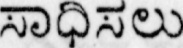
ಸಾಧಿಸಲು
